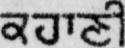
ਕਹਾਣੀ
